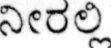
ನೀರಲ್ಲಿ
